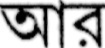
আর
